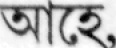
আহে,
